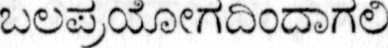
ಬಲಪ್ರಯೋಗದಿಂದಾಗಲಿ
